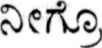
ನೀಗ್ರೊ
